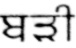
ਬੜੀ
